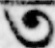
ত
